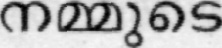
നമ്മുടെ
